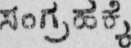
ಸಂಗ್ರಹಕ್ಕೆ
